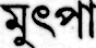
মুৎপা
